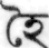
হৈ
